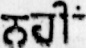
ਨਹੀਂ
